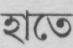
হাতে
